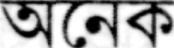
অনেক
